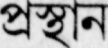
প্রস্থান
